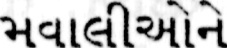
મવાલીઓને
